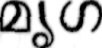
മൃഗ
